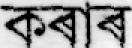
কৰাৰ
